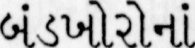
બંડખોરોનાં
